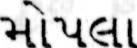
મોપલા
